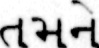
તમને
